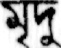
মৃদু
